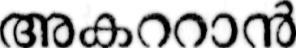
അകററാന്‍
